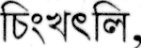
চিংখৎলি,
